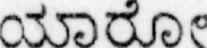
ಯಾರೋ
